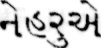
નેહરુએ
